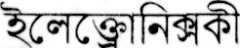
ইলেক্ত্রোনিক্সকী
